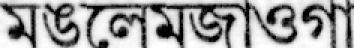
মঙলেমজাওগা
